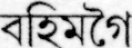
বহিমগৈ
